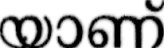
യാണ്
